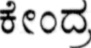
ಕೇಂದ್ರ
